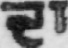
ਦਾ
